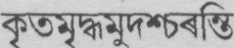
কৃতমৃদ্ধমুদ্চৰন্তি
